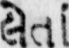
લેતાં
